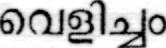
വെളിച്ചം
